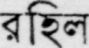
রহিল
